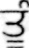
ਤੂੰ
